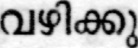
വഴിക്കു
